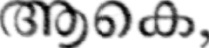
ആകെ,
